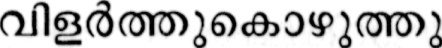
വിളര്‍ത്തുകൊഴുത്തു
